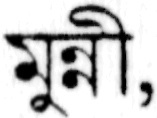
মুন্নী,
